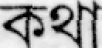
কথা
